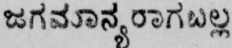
ಜಗಮಾನ್ಯರಾಗಬಲ್ಲ
